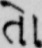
તો
